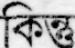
কিন্তু
